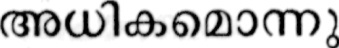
അധികമൊന്നു
